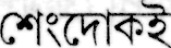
শেংদোকই
